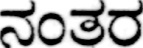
ನಂತರ
